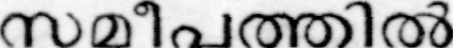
സമീപത്തില്‍
